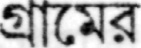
গ্রামের
